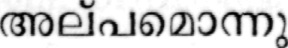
അല്പമൊന്നു
